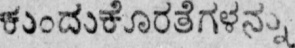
ಕುಂದುಕೊರತೆಗಳನ್ನು
